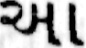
આ
